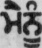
ਮੈਨੂੰ
